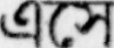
এসে
